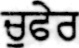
ਚੁਫੇਰ
